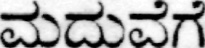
ಮದುವೆಗೆ
